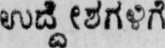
ಉದ್ದೇಶಗಳಿಗೆ
